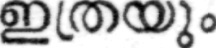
ഇത്രയും
